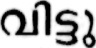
വിട്ടു
